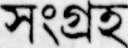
সংগ্রহ
